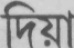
দিয়া
